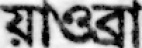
য়াওব্রা
